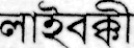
লাইবক্কী
